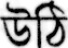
উঠি
